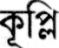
কূপ্লি
